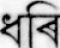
ধৰি
